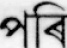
পৰি
